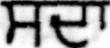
ਸਦਾ
